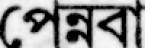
পেন্নবা
